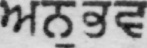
ਅਨੁਭਵ
